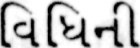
વિધિની
